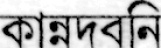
কান্নদবনি
